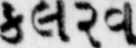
કલરવ
